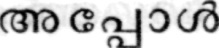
അപ്പോള്‍
